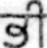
ਭੀ
